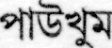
পাউখুম
